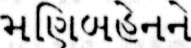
મણિબહેનને
